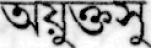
অয়ুক্তসু
